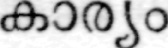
കാര്യം
